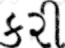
કરી
